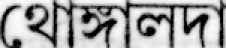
থোঙ্গালদা
